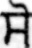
ਸੋ
